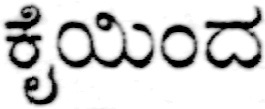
ಕೈಯಿಂದ
